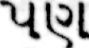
પણ
